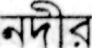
নদীর
